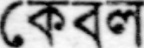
কেবল
